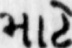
માટે
